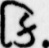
કિ.
